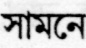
সামনে
